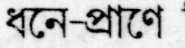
ধনে-প্রাণে
